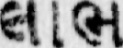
લાભ
